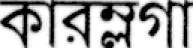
কারম্লগা
